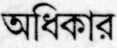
অধিকার
